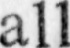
all
